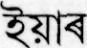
ইয়াৰ
